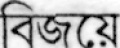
বিজয়ে
